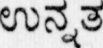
ಉನ್ನತ
